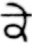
ਕੇ
